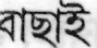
বাছাই
